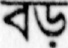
বড়
